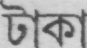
টাকা
